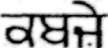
ਕਬਜ਼ੇ
